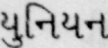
યુનિયન
